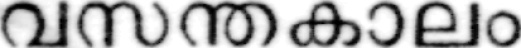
വസന്തകാലം
